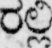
ರಲ್ಲಿ
